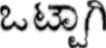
ಒಟ್ಟಾಗಿ
